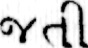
જતી
